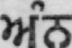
ਅੰਨ
